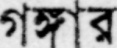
গঙ্গার
